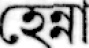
হেন্না
